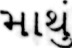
માથું
